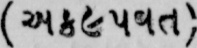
(અકલ્પવત)
